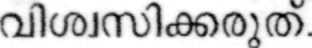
വിശ്വസിക്കരുത്.
